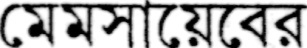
মেমসায়েবের
